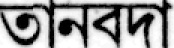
তানবদা
